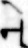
ને
